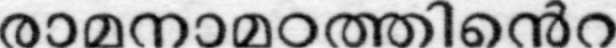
രാമനാമഠത്തിന്റെ
